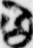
છે
